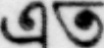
এত
